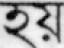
হয়
